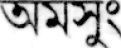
অমসুং
